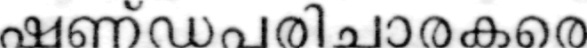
ഷണ്ഡപരിചാരകരെ
